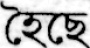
হৈছে
